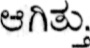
ಆಗಿತ್ತು.
